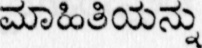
ಮಾಹಿತಿಯನ್ನು
